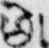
છો
